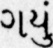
ગયું
